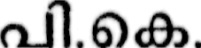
പി.കെ.
